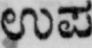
ಉಪ
